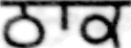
ਠਾਕ
